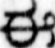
ಈ
